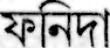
ফনিদা
